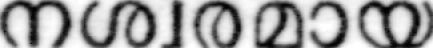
നശ്വരമായ
